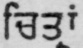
ਚਿਤ੍ਰਾਂ
